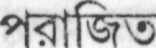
পরাজিত
